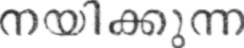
നയിക്കുന്ന
